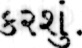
કરશું.
